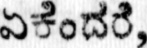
ಏಕೆಂದರೆ,
